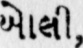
બોલી,
